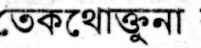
তেকথোক্তুনা
